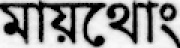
মায়থোং
